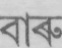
বাৰু
